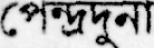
পেন্দ্রদুনা
